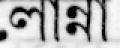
লোন্না
